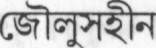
জৌলুসহীন
